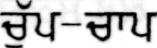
ਚੁੱਪ-ਚਾਪ
